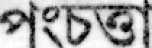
পংচত্তা
